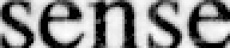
sense
